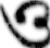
ও
